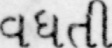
વધતી
